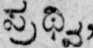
ಪ್ರಥ್ವಿ,
